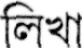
লিখা
